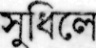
সুধিলে
